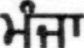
ਮੰਜਾ
